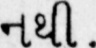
નથી.
